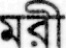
মরী
